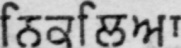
ਨਿਕਲਿਆ
